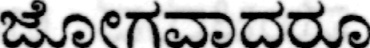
ಜೋಗವಾದರೂ
